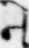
ને
